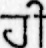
ਹੀ
